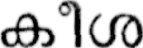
കീശ
